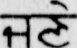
ਜਣੇ
